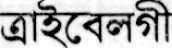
ত্রাইবেলগী
